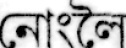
নোংলৈ
